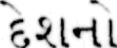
દેશનો
